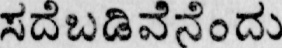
ಸದೆಬಡಿವೆನೆಂದು
